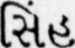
સિંહ
